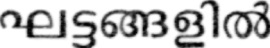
ഘട്ടങ്ങളില്‍
